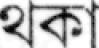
থকা
